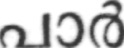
പാര്‍
